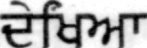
ਦੇਖਿਆ
